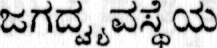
ಜಗದ್ವ್ಯವಸ್ಥೆಯ
